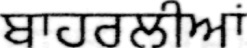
ਬਾਹਰਲੀਆਂ
